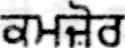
ਕਮਜ਼ੋਰ
